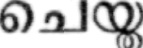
ചെയ്ത
